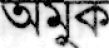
অমুক
